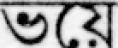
ভয়ে
